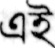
এই
